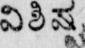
ವಿಶಿಷ್ಟ
